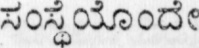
ಸಂಸ್ಥೆಯೊಂದೇ
